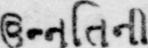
ઉન્નતિની
